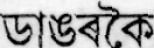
ডাঙৰকৈ
